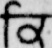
ਕਿ
